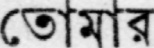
তোমার
